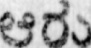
ಆರು
